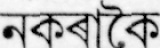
নকৰাকৈ
